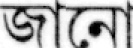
জানো
